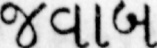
જવાબ
